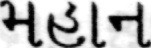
મહાન
